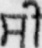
ਸੀ
